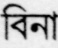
বিনা
